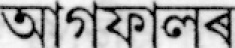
আগফালৰ
